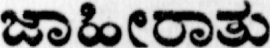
ಜಾಹೀರಾತು
